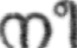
നീ
